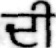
ਦੀ
